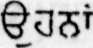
ਉਹਨਾਂ
